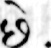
છે.
